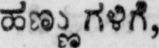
ಹಣ್ಣುಗಳಿಗೆ,
